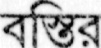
বস্তির
